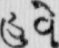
હવે
